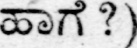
ಹಾಗೆ?)
